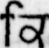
ਕਿ
